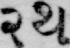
રથ
